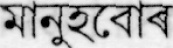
মানুহবোৰ
